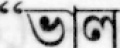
"ভাল
